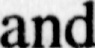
and
